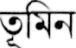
তূমিন
